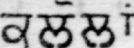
ਕਲੋਲਾਂ
